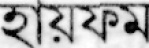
হায়ফম
